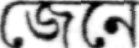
জেনে
